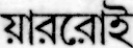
য়াররোই
